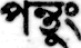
পন্থুং
